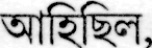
আহিছিল,
